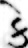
કે
